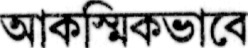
আকস্মিকভাবে
